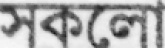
সকলো
